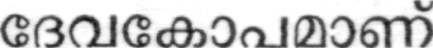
ദേവകോപമാണ്
